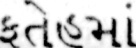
ફતેહમાં
